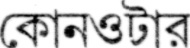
কোনওটার
